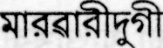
মারৱারীদুগী
